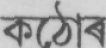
কঠোৰ
